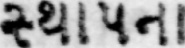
સ્થાપના
